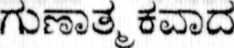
ಗುಣಾತ್ಮಕವಾದ
